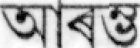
আৰম্ভ
